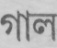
গাল
